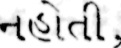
નહોતી,
